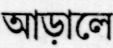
আড়ালে
